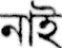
নাই
